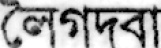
লৈগদবা
